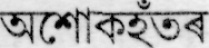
অশোকহঁতৰ
